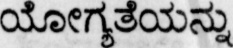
ಯೋಗ್ಯತೆಯನ್ನು
